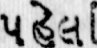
પહેલાં
